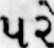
પરે
